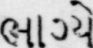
ભાગ્યે
